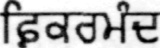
ਫ਼ਿਕਰਮੰਦ
